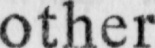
other
